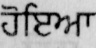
ਹੋਇਆ
